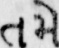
તમે
